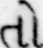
તો
